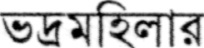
ভদ্রমহিলার
